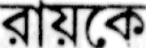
রায়কে
